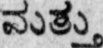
ಮತ್ತು
